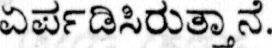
ಏರ್ಪಡಿಸಿರುತ್ತಾನೆ.
